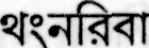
থংনরিবা
